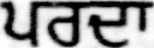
ਪਰਦਾ
